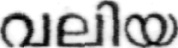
വലിയ
